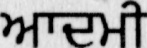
ਆਦਮੀ
